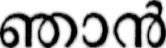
ഞാന്‍
